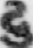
ટુ
